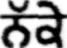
ਨੱਕੇ
